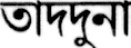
তাদদুনা
